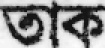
তাক
